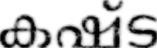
കഷ്ട
